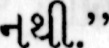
નથી."
